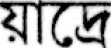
য়াদ্রে
